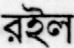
রইল
